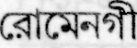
রোমেনগী
